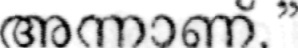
അന്നാണ്."
